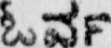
ಓರ್ವ
